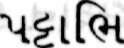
પટ્ટાભિ
